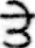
ਤੇ
